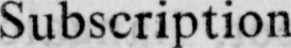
Subscription
